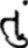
તું
